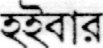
হইবার
